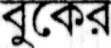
বুকের
